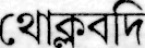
থোক্লবদি
